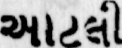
આટલી
